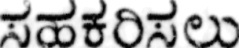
ಸಹಕರಿಸಲು
